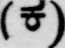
(ಕ)
